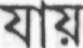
যায়
